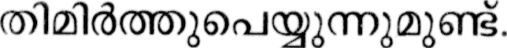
തിമിര്‍ത്തുപെയ്യുന്നുമുണ്ട്.
